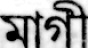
মাগী
